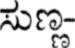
ಸುಣ್ಣ-
